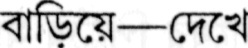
বাড়িয়ে-দেখে
